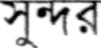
সুন্দর
